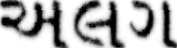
અલગ
